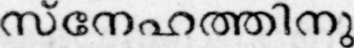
സ്നേഹത്തിനു
